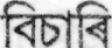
বিচাৰি
